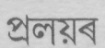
প্ৰলয়ৰ
